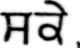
ਸਕੇ,
